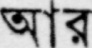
আর
